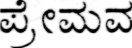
ಪ್ರೇಮವ
